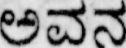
ಅವನ
